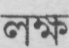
লক্ষ
